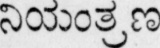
ನಿಯಂತ್ರಣ
